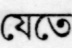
যেতে
